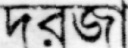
দরজা
